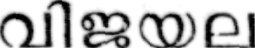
വിജയല
